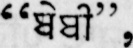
''ਬੇਬੀ'',
